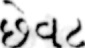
છેવટ
